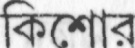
কিশোর
